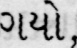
ગયો,
